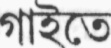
গাইতে
